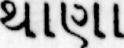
થાણા
